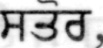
ਸਤੋਰ,
